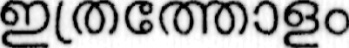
ഇത്രത്തോളം
